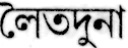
লৈতদুনা
